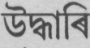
উদ্ধাৰি
